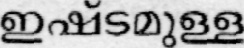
ഇഷ്ടമുള്ള
